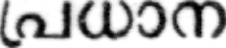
പ്രധാന
